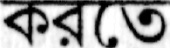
করতে
